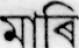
মাৰি
